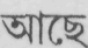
আছে
